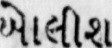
બોલીશ
